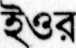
ইওর
